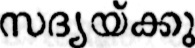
സദ്യയ്ക്കു
